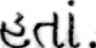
હતાં.
